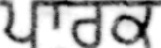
ਪਾਰਕ
